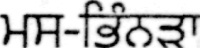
ਮਸ-ਭਿੰਨੜਾ
